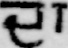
ਦਾ
